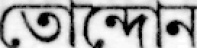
তোন্দোন
